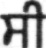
ਸੀ
